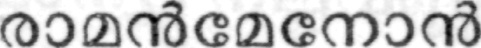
രാമന്‍മേനോന്‍
